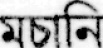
মচানি
